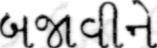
બજાવીને
